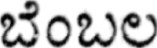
ಬೆಂಬಲ
